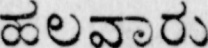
ಹಲವಾರು
